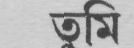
তুমি
